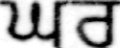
ਘਰ
